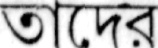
তাদের
